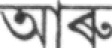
আৰু
